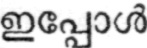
ഇപ്പോള്‍
